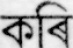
কৰি
